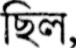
ছিল,
